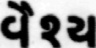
વૈશ્ય
